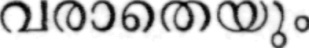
വരാതെയും
